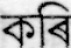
কৰি
